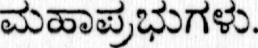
ಮಹಾಪ್ರಭುಗಳು.
